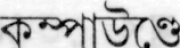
কম্পাউণ্ডে
